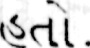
હતો.
